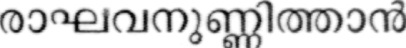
രാഘവനുണ്ണിത്താന്‍
